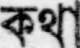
কথা
